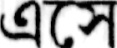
এসে
